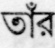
তাঁর
